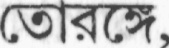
তোরঙ্গে,
